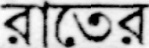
রাতের
